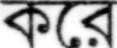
করে
